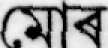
মোৰ
